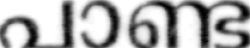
പാണ്ട
